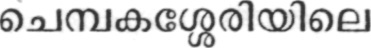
ചെമ്പകശ്ശേരിയിലെ
